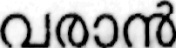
വരാന്‍
